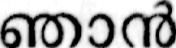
ഞാന്‍
